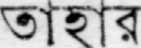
তাহার
